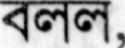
বলল,
